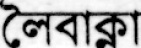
লৈবাক্না
